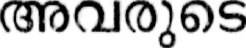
അവരുടെ
